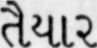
તૈયાર
